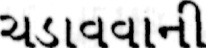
ચડાવવાની
